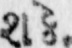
શકે.
